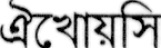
ঐখোয়সি
